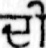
ਦੀ
